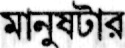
মানুষটার
